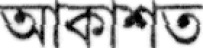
আকাশত
